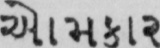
ઓમકાર
